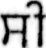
ਸੀ
